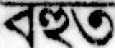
বহুত
